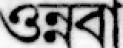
ওন্নবা
